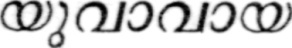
യുവാവായ
